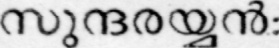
സുന്ദരയ്യന്‍:
